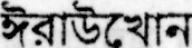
ঈরাউখোন
